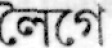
লৈগে
